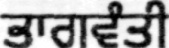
ਭਾਗਵੰਤੀ
